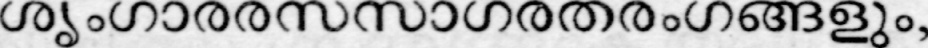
ശൃംഗാരരസസാഗരതരംഗങ്ങളും,
